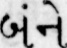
બંને
